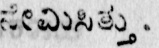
ನೇಮಿಸಿತ್ತು.
